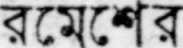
রমেশের
